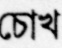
চোখ
